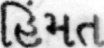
હિંમત
